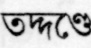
তদ্দণ্ডে
